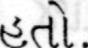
હતો.
